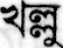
খল্লু
